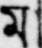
মা
